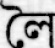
লৈ
